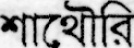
শাথৌরি
